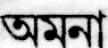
অমনা
